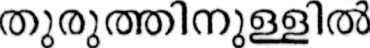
തുരുത്തിനുള്ളില്‍
